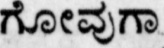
ಗೋವುಗಾ
